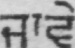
ਜਾਵੇ
